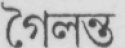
গৈলন্ত
